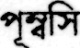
পূম্বসি
